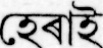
হেৰাই
